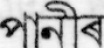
পানীৰ
